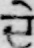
ਦੇ
